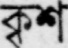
কৃশ
